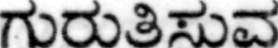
ಗುರುತಿಸುವ
